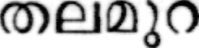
തലമുറ
